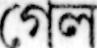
গেল
